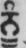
ਨੂੰ
